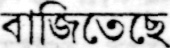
বাজিতেছে
